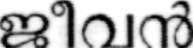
ജീവന്‍
